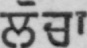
ਲੋਚਾ
